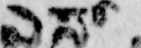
ಎಸ್.
